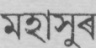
মহাসুৰ
